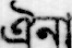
ঐনা
